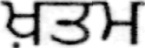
ਖ਼ਤਮ
